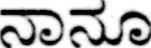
ನಾನೂ
